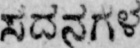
ಸದನಗಳ
